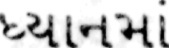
ધ્યાનમાં
